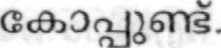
കോപ്പുണ്ട്.
